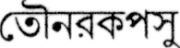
তৌনরকপসু
